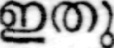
ഇതു
